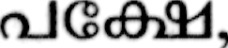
പക്ഷേ,
